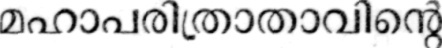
മഹാപരിത്രാതാവിന്റെ
